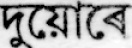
দুয়োৰে
